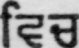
ਵਿਚ
